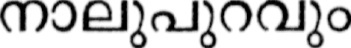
നാലുപുറവും
